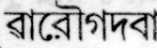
ৱারৌগদবা
